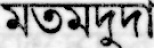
মতমদুদা
